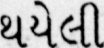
થયેલી
